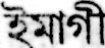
ইমাগী
